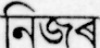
নিজৰ
